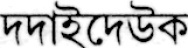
দদাইদেউক
